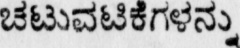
ಚಟುವಟಿಕೆಗಳನ್ನು
